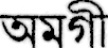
অমগী
